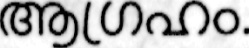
ആഗ്രഹം.
